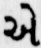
એ
